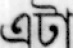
এটা
